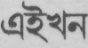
এইখন
